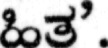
ಹಿತ’.
